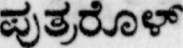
ಪುತ್ರರೊಳ್
